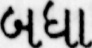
બધા
